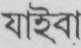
যাইবা
